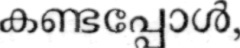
കണ്ടപ്പോള്‍,
